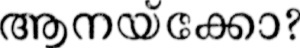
ആനയ്ക്കോ?
